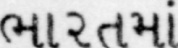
ભારતમાં
